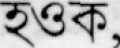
হওক,
